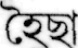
হৈছা
